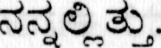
ನನ್ನಲ್ಲಿತ್ತು.
